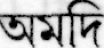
অমদি
